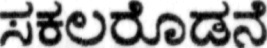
ಸಕಲರೊಡನೆ
